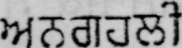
ਅਨਗਹਲੀ
